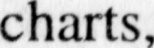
charts,
